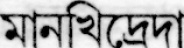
মানখিদ্রেদা
